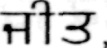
ਜੀਤ,
